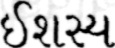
ઈશસ્ય
